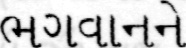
ભગવાનને
